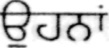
ਉਹਨਾਂ
